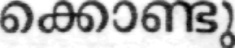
ക്കൊണ്ടു
